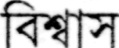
বিশ্বাস
